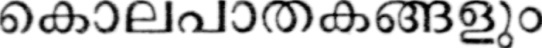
കൊലപാതകങ്ങളും
